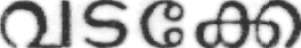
വടക്കേ
